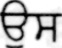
ਉਸ
